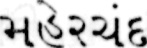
મહેરચંદ
